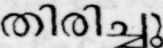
തിരിച്ചു
